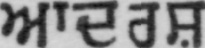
ਆਦਰਸ਼
